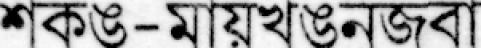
শকঙ-মায়খঙনজবা
